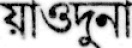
য়াওদুনা
